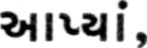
આપ્યાં,
